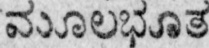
ಮೂಲಭೂತ
